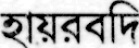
হায়রবদি
